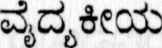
ವೈದ್ಯಕೀಯ
